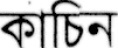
কাচিন
